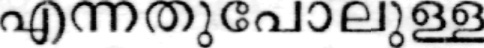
എന്നതുപോലുള്ള
